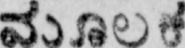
ಮೂಲಕ
